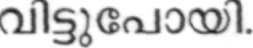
വിട്ടുപോയി.
